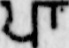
ਪਾ
